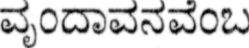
ವೃಂದಾವನವೆಂಬ
